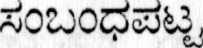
ಸಂಬಂಧಪಟ್ಟ
